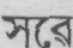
সৱে
